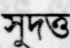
সুদত্ত
